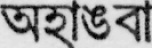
অহাঙবা
